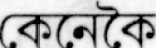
কেনেকৈ
